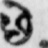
છે.
